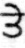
ਤੇ
